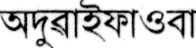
অদুৱাইফাওবা
